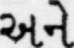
અને
